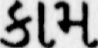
કામ
